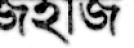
জহাজ
